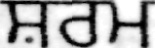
ਸ਼ਰਮ
